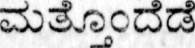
ಮತ್ತೊಂದೆಡೆ
